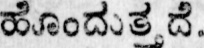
ಹೊಂದುತ್ತದೆ.
